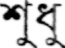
শুধু
